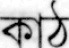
কাঠ
